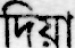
দিয়া
